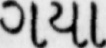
ગયા
